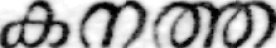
കനത്ത
